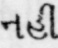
નહીં
